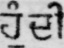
ਹੁੰਦੀ
